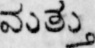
ಮತ್ತು
